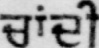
ਚਾਂਦੀ
